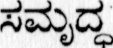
ಸಮೃದ್ಧ
